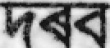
দৰব
